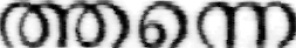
ത്തന്നെ
